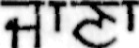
ਜਾਣਾ
